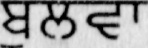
ਬੁਲਵਾ
